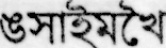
ঙসাইমখৈ
